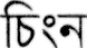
চিংন
